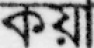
কয়া
